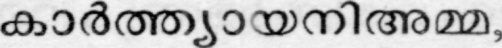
കാര്‍ത്ത്യായനിഅമ്മ,
